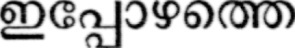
ഇപ്പോഴത്തെ
